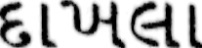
દાખલા
